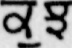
ਕੁਝ
